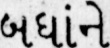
બધાંને
